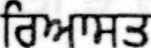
ਰਿਆਸਤ
